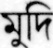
মুদি
